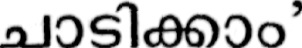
ചാടിക്കാം’
